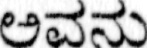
ಅವನು
